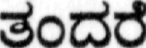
ತಂದರೆ
